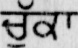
ਚੁੱਕਾ
